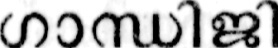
ഗാന്ധിജി
